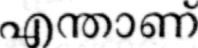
എന്താണ്
